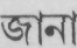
জানা
